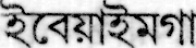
ইবেয়াইমগা
